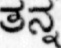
ತನ್ನ
